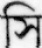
সি
